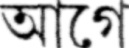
আগে
